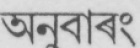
অনুবাৰং
